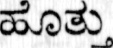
ಹೊತ್ತು
